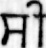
ਸੀ
